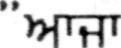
''ਆਜਾ
